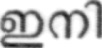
ഇനി
